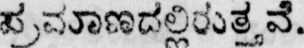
ಪ್ರಮಾಣದಲ್ಲಿರುತ್ತವೆ.
